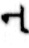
ન
